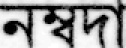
নম্বদা
